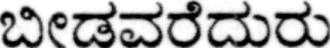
ಬೀಡವರೆದುರು
